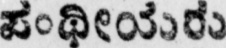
ಪ೦ಥೀಯರು
